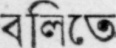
বলিতে
